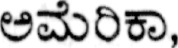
ಅಮೆರಿಕಾ,
